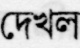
দেখল
